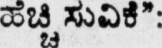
ಹೆಚ್ಚಿಸುವಿಕೆ”:
